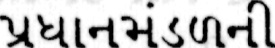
પ્રધાનમંડળની
